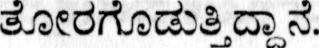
ತೋರಗೊಡುತ್ತಿದ್ದಾನೆ.
